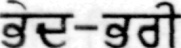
ਭੇਦ-ਭਰੀ
